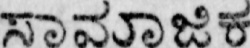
ಸಾಮಾಜಿಕ
